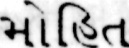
મોહિત
